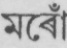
মৰোঁ
